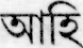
আহি
